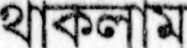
থাকলাম
